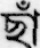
ছাঁ
